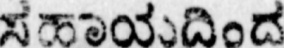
ಸಹಾಯದಿಂದ
